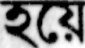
হয়ে
